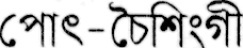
পোৎ-চৈশিংগী
